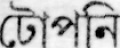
টোপনি
